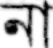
না
